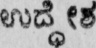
ಉದ್ದೇಶ
